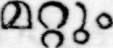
മറ്റും
